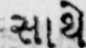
સાથે
